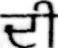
ਦੀ
